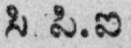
ಸಿ.ಪಿ.ಐ
